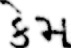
કેમ
